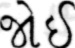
જોઈ
